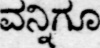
ವನ್ನಿಗೂ
